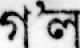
গ'ল
